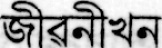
জীৱনীখন
